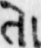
તો
